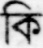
কি
